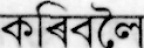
কৰিবলৈ
